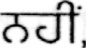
ਨਹੀਂ,
